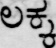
ಲಕ್ಕ
